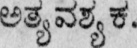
ಅತ್ಯವಶ್ಯಕ.
